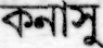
কনাসু
